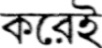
করেই
